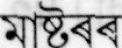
মাষ্টৰৰ
